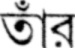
তাঁর
